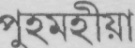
পুহমহীয়া
